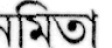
নমিতা
